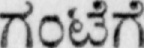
ಗಂಟೆಗೆ
